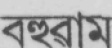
বহুৱাম
